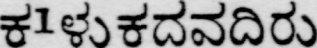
ಕ1ಳುಕದವದಿರು
